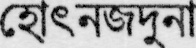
হোৎনজদুনা
